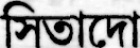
সিতাদো
